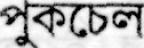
পুকচেল
